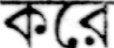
করে
